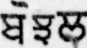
ਬੋਝਲ
